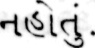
નહોતું.
